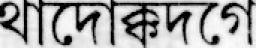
থাদোক্কদগে
